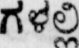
ಗಳಲ್ಲಿ
